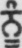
ਨੂੰ
